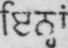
ਇਨ੍ਹਾਂ
